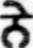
ਨੇ
